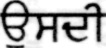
ਉਸਦੀ
